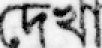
দেখা
